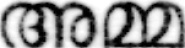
അമ്മ
